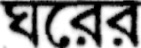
ঘরের
